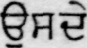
ਉਸਦੇ
